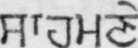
ਸਾਹਮਣੇ
